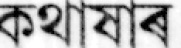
কথাষাৰ
